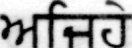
ਅਜਿਹੇ
